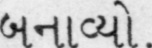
બનાવ્યો.
